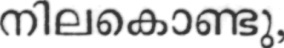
നിലകൊണ്ടു,
